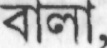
বালা,
